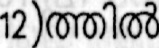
12)ത്തില്‍
